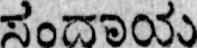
ಸಂದಾಯ
